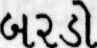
બરડો
